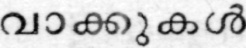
വാക്കുകള്‍
